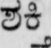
ಶಕ್ತಿ
